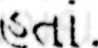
હતાં.
